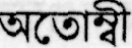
অতোম্বী
